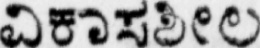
ವಿಕಾಸಶೀಲ
